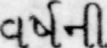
વર્ષની
